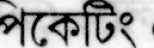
পিকেটিং
